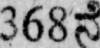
368ನೆ
